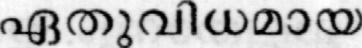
ഏതുവിധമായ
